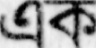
এক
